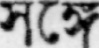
সঙ্গে
